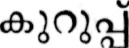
കുറുപ്പ്
